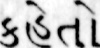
કહેતો
